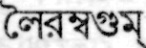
লৈরম্বগুম্
